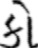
કો
